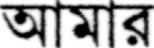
আমার
